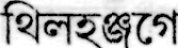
থিলহঞ্জগে
